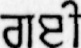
ਗਈ
